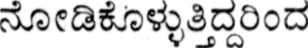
ನೋಡಿಕೊಳ್ಳುತ್ತಿದ್ದರಿಂದ
